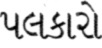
પલકારો
